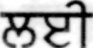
ਲਈ
